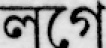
লগে
